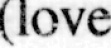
(love
